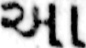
આ
